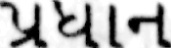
પ્રધાન
